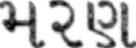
મરણ
